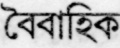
বৈবাহিক
